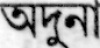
অদুনা
